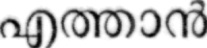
എത്താന്‍
